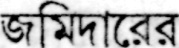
জমিদারের
